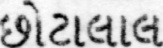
છોટાલાલ
